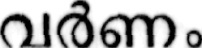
വര്‍ണം
